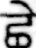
ਛੇ
